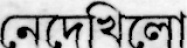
নেদেখিলো
